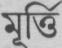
মূৰ্ত্তি
